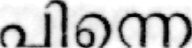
പിന്നെ
